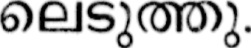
ലെടുത്തു.
